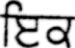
ਇਕ
